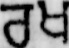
ਰਖ
